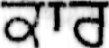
ਕਾਰ
